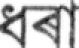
ধৰা
